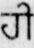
ਹੀ
